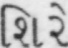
શિરે
